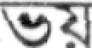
ভয়
